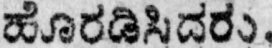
ಹೊರಡಿಸಿದರು,
